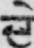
ਦੇ
